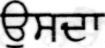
ਉਸਦਾ
